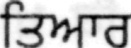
ਤਿਆਰ
